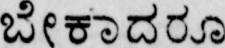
ಬೇಕಾದರೂ
